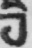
ਹੈ
